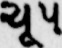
ચૂપ
